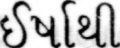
ઈર્ષાથી
